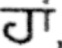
ਹਾਂ,
